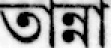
তান্না
